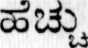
ಹೆಚ್ಚು
